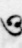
ও
